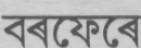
বৰফেৰে
